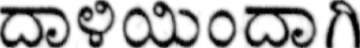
ದಾಳಿಯಿಂದಾಗಿ
